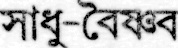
সাধু-বৈষ্ণবৱ
